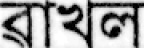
ৱাখল
